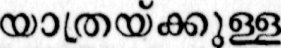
യാത്രയ്ക്കുള്ള
